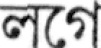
লগে
